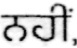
ਨਹੀਂ,
